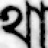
থা
